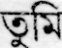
তুমি
